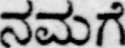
ನಮಗೆ
